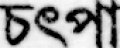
চৎপা
